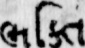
ભક્તિ
